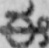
ಈ
